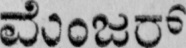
ಮೆಂಜರ್
